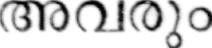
അവരും
